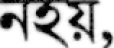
নহয়,
